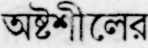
অষ্টশীলের
